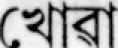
খোৱা
